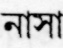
নাসা
